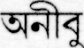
অনীবু
